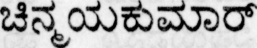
ಚಿನ್ಮಯಕುಮಾರ್
